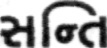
સન્તિ
